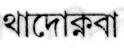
থাদোক্নবা
